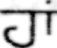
ਹਾਂ
